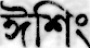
ঈশিং
